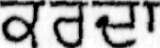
ਕਰਦਾ
